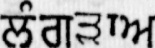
ਲੰਗੜਾਅ
